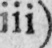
iii)
